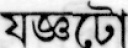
যজ্ঞটো
